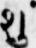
શું
